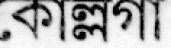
কোল্লগা
